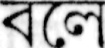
বলে
